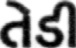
તેડી
